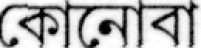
কোনোবা
